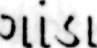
ગાંડા
